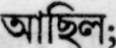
আছিল;
